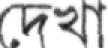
দেখা
